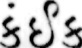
કંઈક
